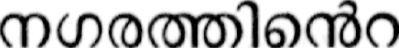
നഗരത്തിന്റെ
